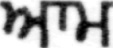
ਆਮ
